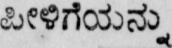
ಪೀಳಿಗೆಯನ್ನು
